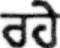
ਰਹੇ
